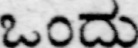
ಒಂದು
